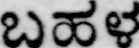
ಬಹಳ
